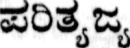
ಪರಿತ್ಯಜ್ಯ
